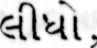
લીધો,
